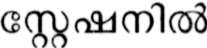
സ്റ്റേഷനില്‍
